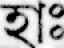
হাঃ
